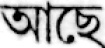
আছে
